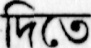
দিতে
